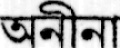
অনীনা
